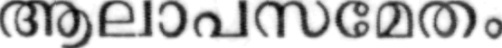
ആലാപസമേതം
